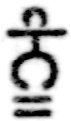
ਨੂੰ
